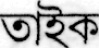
তাইক
